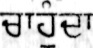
ਚਾਹੁੰਦਾ
